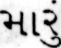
મારું
